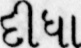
દીધા
